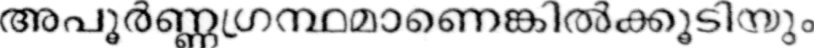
അപൂര്‍ണ്ണഗ്രന്ഥമാണെങ്കില്‍ക്കൂടിയും
